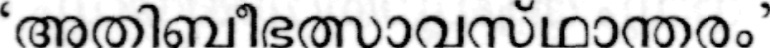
‘അതിബീഭത്സാവസ്ഥാന്തരം'
